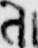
તો
